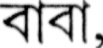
বাবা,
